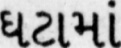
ઘટામાં
